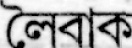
লৈবাক
